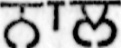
ਨਾਲ
